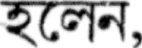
হলেন,
